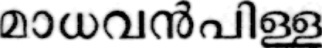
മാധവന്‍പിള്ള
